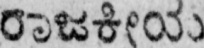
ರಾಜಕೀಯ
